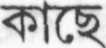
কাছে
